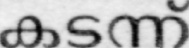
കടന്ന്
